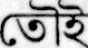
তৌই
